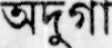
অদুগা
